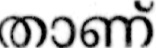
താണ്
